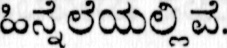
ಹಿನ್ನೆಲೆಯಲ್ಲಿವೆ.
